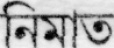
নিমাত
